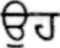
ਉਹ
